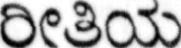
ರೀತಿಯ
